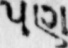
પણ
